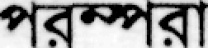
পরম্পরা
